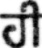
ਹੀ
